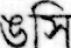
ঙসি
